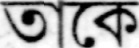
তাকে
